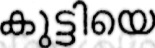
കുട്ടിയെ
